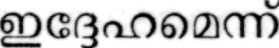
ഇദ്ദേഹമെന്ന്
